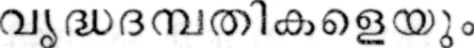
വൃദ്ധദമ്പതികളെയും
